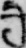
ਹੈ
